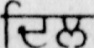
ਦਿਲ
